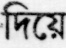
দিয়ে
